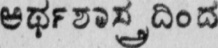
ಅರ್ಥಶಾಸ್ತ್ರದಿಂದ
